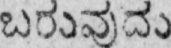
ಬರುವುದು
